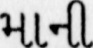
માની
